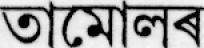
তামোলৰ
